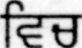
ਵਿਚ
